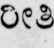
ರೀತಿ
